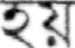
হয়
